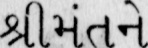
શ્રીમંતને
